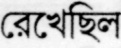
রেখেছিল
